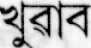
খুৱাব
